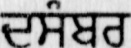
ਦਸੰਬਰ
